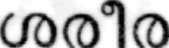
ശരീര
